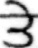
ਤੇ
